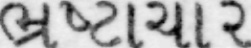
ભ્રષ્ટાચાર
